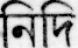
নিদি
